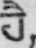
ਹੈ,
